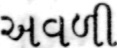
અવળી
